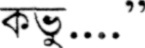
কভু....”
